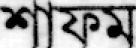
শাফম
